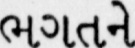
ભગતને
